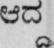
ಆದ್ದ
